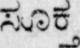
ಸೂಕ್ತ
